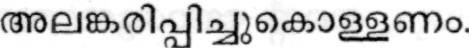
അലങ്കരിപ്പിച്ചുകൊള്ളണം.
